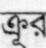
ক্রূর
